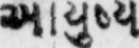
આયુષ્ય
